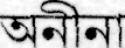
অনীনা
